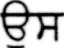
ਉਸ
